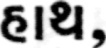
હાથ,
